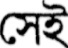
সেই
